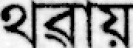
থৱায়
